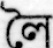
লৈ
